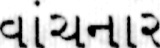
વાંચનાર
